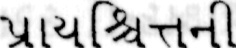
પ્રાયશ્ચિત્તની
